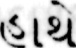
હાથે
